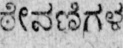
ಠೇವಣಿಗಳ
